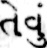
તેવું
